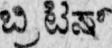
ಬ್ರಿಟಿಷ್
